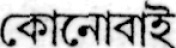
কোনোবাই
